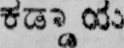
ಕಡ್ಡಾಯ
